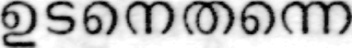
ഉടനെതന്നെ
